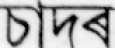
চাদৰ
